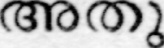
അതു
